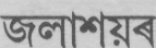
জলাশয়ৰ
